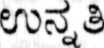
ಉನ್ನತಿ
